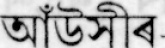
আঁউসীৰ
